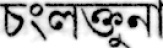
চংলক্তুনা
